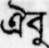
ঐবু
